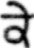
ਕੇ
